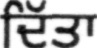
ਦਿੱਤਾ
